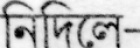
নিদিলে-
